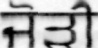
ਜੋੜੀ
